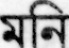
মনি
